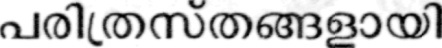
പരിത്രസ്തങ്ങളായി
